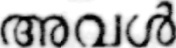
അവള്‍
